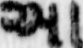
આ
